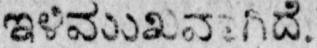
ಇಳಿಮುಖವಾಗಿದೆ.
